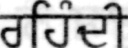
ਰਹਿੰਦੀ
